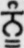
ਨੂੰ
